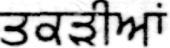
ਤਕੜੀਆਂ
